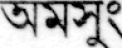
অমসুং
